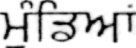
ਮੁੰਡਿਆਂ
